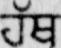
ਹੱਥ
